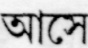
আসে
